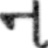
ન
